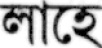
লাহে
